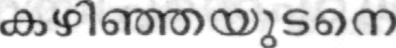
കഴിഞ്ഞയുടനെ
